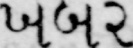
ખબર
